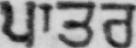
ਪਾਤਰ
